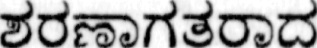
ಶರಣಾಗತರಾದ
